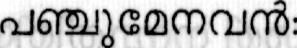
പഞ്ചുമേനവന്‍:
